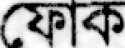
ফোক
